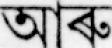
আৰু
